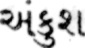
અંકુશ
